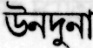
উনদুনা
